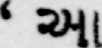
'આ
